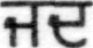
ਜਦ
